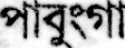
পাবুংগা
